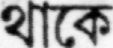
থাকে
